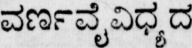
ವರ್ಣವೈವಿಧ್ಯದ
